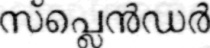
സ്പ്ലെന്‍ഡര്‍
